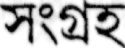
সংগ্রহ
